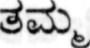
ತಮ್ಮ
